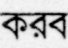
করব
